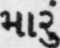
મારું
